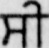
ਸੀ
